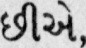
છીએ,
